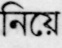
নিয়ে
